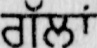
ਗੱਲਾਂ
